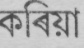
কৰিয়া
